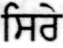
ਸਿਰੇ
